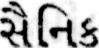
સૈનિક
